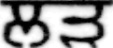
ਲੜ
